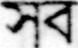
সব
